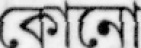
কোনো
